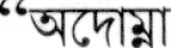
“অদোম্না
